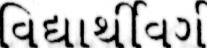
વિધાર્થીવર્ગ
